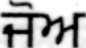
ਜੋਅ
